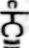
ਨੂੰ
